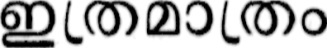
ഇത്രമാത്രം
